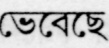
ভেবেছে
